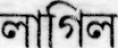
লাগিল
